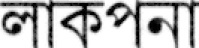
লাকপনা
